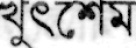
খুৎশেম
